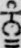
ਨੂੰ
